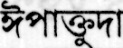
ঈপাক্তুদা
